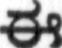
ಈ
